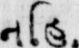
નહિ.
